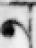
ন
